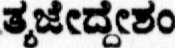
ತ್ಯಜೇದ್ದೇಶಂ
